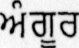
ਅੰਗੂਰ
